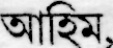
আহিম,
